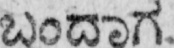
ಬಂದಾಗ,
